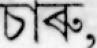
চাৰু,
